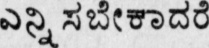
ಎನ್ನಿಸಬೇಕಾದರೆ
